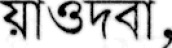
য়াওদবা,
